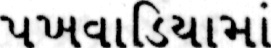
પખવાડિયામાં
